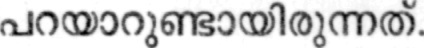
പറയാറുണ്ടായിരുന്നത്.
